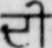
ਦੀ
